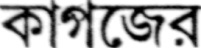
কাগজের
